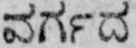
ವರ್ಗದ
